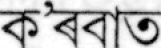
ক'ৰবাত
